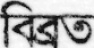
বিব্রত
